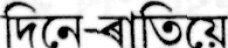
দিনে-ৰাতিয়ে
